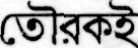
তৌরকই
